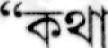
"কথা
